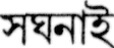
সঘনাই
